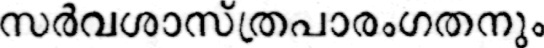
സര്‍വശാസ്ത്രപാരംഗതനും
